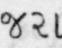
જરા
